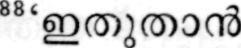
88'ഇതുതാന്‍
